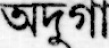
অদুগা
